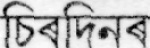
চিৰদিনৰ
